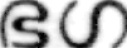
ഭഗ
